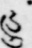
હું
